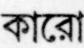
কারো
